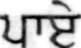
ਪਾਏ
